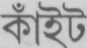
কাঁইট
